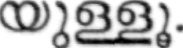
യുള്ളൂ.
